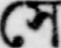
সে
